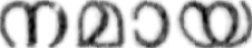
നമായ
